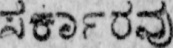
ಸರ್ಕಾರವು
